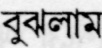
বুঝলাম
